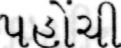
પહોંચી
